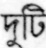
দুটি
